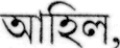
আহিল,
